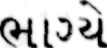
ભાગ્યે
